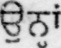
ਉਨ੍ਹਾਂ
